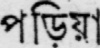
পড়িয়া
